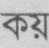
কয়
